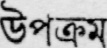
উপক্রম
